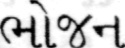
ભોજન
